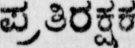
ಪ್ರತಿರಕ್ಷಕ
